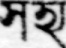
সহ্য
